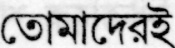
তোমাদেরই
